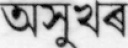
অসুখৰ
